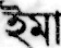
ইমা
